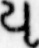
ય
